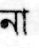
না
